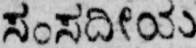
ಸಂಸದೀಯ
